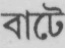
বাটে
